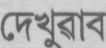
দেখুৱাব
